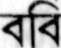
ববি
